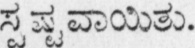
ಸ್ಪಷ್ಟವಾಯಿತು.
